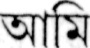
আমি
